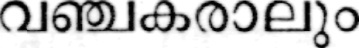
വഞ്ചകരാലും
